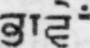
ਭਾਵੇਂ
